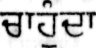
ਚਾਹੁੰਦਾ
